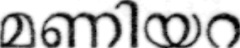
മണിയറ
